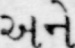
અને
